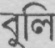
বুলি
